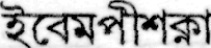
ইবেমপীশক্না
